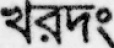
খরদং
